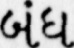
બંધ
